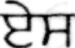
ਏਸ
